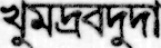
খুমদ্রবদুদা
